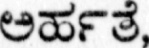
ಅರ್ಹತೆ,
